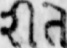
રીતે
